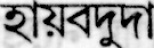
হায়বদুদা
